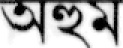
অহুম
